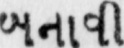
બનાવી
